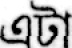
এটা
